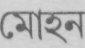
মোহন
